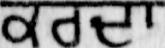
ਕਰਦਾ
